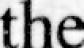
the
